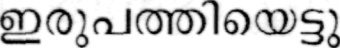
ഇരുപത്തിയെട്ടു
